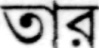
তার
